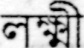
লক্ষ্মী
